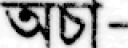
অচা-
